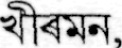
খীৰমন,
